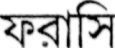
ফরাসি
